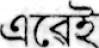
এৱেই
